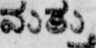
ಮತ್ತು
